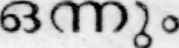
ഒന്നും
